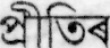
প্রীতিৰ
